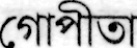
গোপীতা
